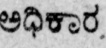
ಅಧಿಕಾರ
